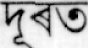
দূৰত
